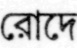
রোদে
